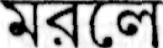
মরলে
